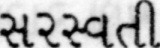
સરસ્વતી
